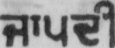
ਜਾਪਦੀ
